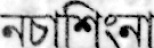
নচাশিংনা
